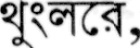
থুংলরে,
